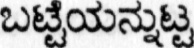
ಬಟ್ಟೆಯನ್ನುಟ್ಟ
